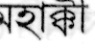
মহাক্কী
